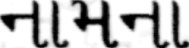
નામના
